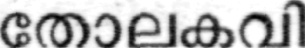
തോലകവി
